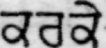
ਕਰਕੇ
